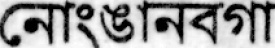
নোংঙানবগা
